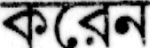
করেন
